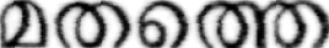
മതത്തെ
